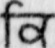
ਕਿ
